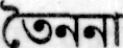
তৈননা
